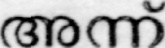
അന്ന്
